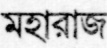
মহারাজ
